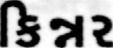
કિન્નર
